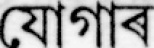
যোগাৰ
